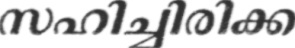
സഹിച്ചിരിക്ക
